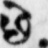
છે.
